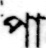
পা
